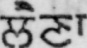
ਲੈਣਾ
